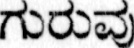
ಗುರುವು
